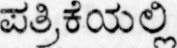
ಪತ್ರಿಕೆಯಲ್ಲಿ
